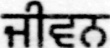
ਜੀਵਨ
